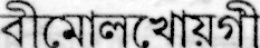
বীমোলখোয়গী
